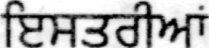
ਇਸਤਰੀਆਂ
